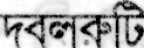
দবলরুটি
